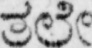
ತಲೇ
